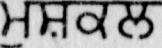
ਮੁਸ਼ਕਲ
